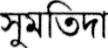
সুমতিদা
